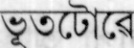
ভূতটোৱে
